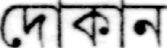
দোকান
